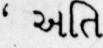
અતિ'
